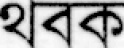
থবক
